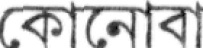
কোনোবা
